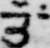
ਤੋਂ
